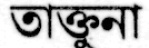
তাক্তুনা
